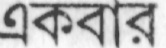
একবার
